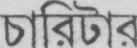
চারিটার
